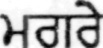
ਮਗਰੇ
